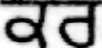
ਕਰ
